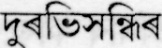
দুৰভিসন্ধিৰ
